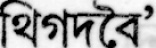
থিগদবৈ’
